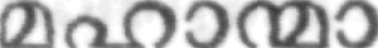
മഹാന്മാ
